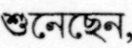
শুনেছেন,
